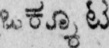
ಒಕ್ಕೂಟ
